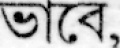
ভাবে,
